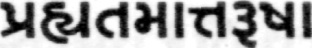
પ્રહ્યતમાત્તરૂષા
